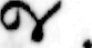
જ.
